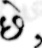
છે,
